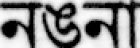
নঙনা
